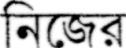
নিজের
